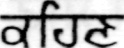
ਕਹਿਣ
